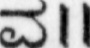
ವ||
